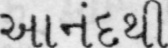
આનંદથી
